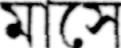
মাসে
